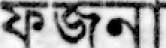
ফজনা
